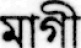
মাগী
